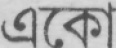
একো
